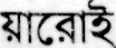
য়ারোই
